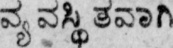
ವ್ಯವಸ್ಥಿತವಾಗಿ
